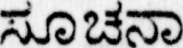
ಸೂಚನಾ
